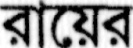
রায়ের
